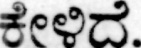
ಕೇಳಿದೆ.
